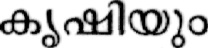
കൃഷിയും
